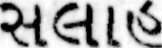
સલાહ
